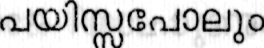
പയിസ്സപോലും
